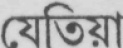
যেতিয়া
